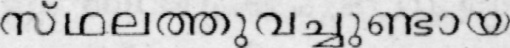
സ്ഥലത്തുവച്ചുണ്ടായ
